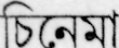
চিনেমা
